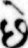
છે
